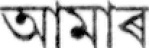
আমাৰ
